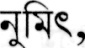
নুমিৎ,
